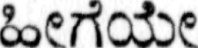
ಹೀಗೆಯೇ
